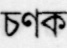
চণক
